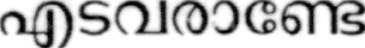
എടവരാണ്ടേ
